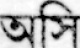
অসি
